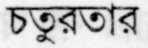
চতুরতার
